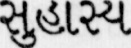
સુહાસ્ય
